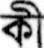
কী
